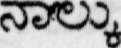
ನಾಲ್ಕು
